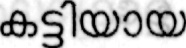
കട്ടിയായ
